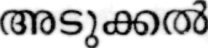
അടുക്കല്‍
